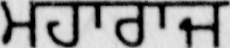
ਮਹਾਰਾਜ
